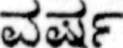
ವರ್ಷ
